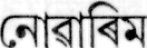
নোৱাৰিম
